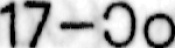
17-ാം
